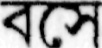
বসে
